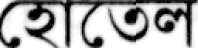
হোতেল
